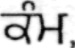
ਕੰਮ,
